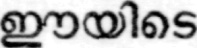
ഈയിടെ
